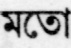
মতো
